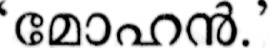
‘മോഹന്‍.’
